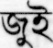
জুই
